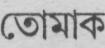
তোমাক
